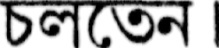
চলতেন।
